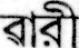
ৱারী
